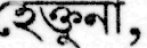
হেক্তুনা,
